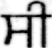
ਸੀ
